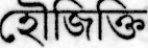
হৌজিক্তি
